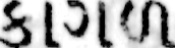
કાગળ
